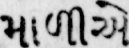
માળીએ
